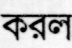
করল
